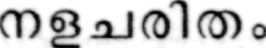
നളചരിതം
